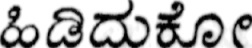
ಹಿಡಿದುಕೋ
